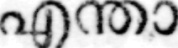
എന്താ
